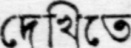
দেখিতে
